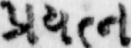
પ્રયત્ન
